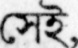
সেই,
